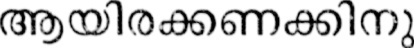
ആയിരക്കണക്കിനു
